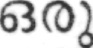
ഒരു
